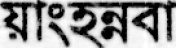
য়াংহন্নবা
